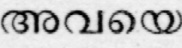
അവയെ
